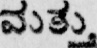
ಮತ್ತು
